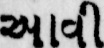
આવી
